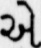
એ
